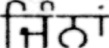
ਜਿੰਨਾਂ
